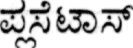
ಪ್ಲಸೆಟಾಸ್
